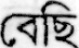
বেছি
